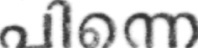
പിന്നെ
